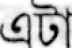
এটা
